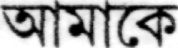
আমাকে
